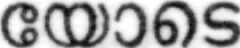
യോടെ
